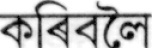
কৰিবলৈ
